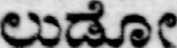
ಲುಡೋ
